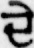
ਦੇ
